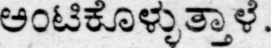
ಅಂಟಿಕೊಳ್ಳುತ್ತಾಳೆ.
